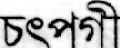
চৎপগী
